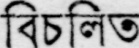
বিচলিত
